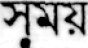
সময়
